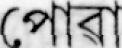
পোৱা
